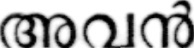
അവന്‍
